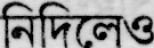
নিদিলেও
